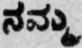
ನಮ್ಮ
